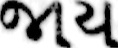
જાય
